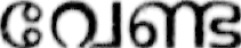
വേണ്ട
